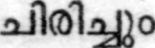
ചിരിച്ചും
